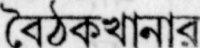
বৈঠকখানার
